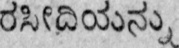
ರಸೀದಿಯನ್ನು
